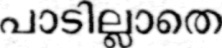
പാടില്ലാതെ
